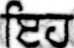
ਇਹ
